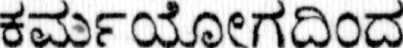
ಕರ್ಮಯೋಗದಿಂದ
